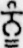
ਨੂੰ
